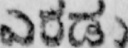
ಎರಡು
